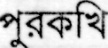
পুরকখি
